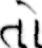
તો
